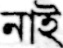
নাই
